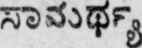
ಸಾಮರ್ಥ್ಯ
